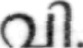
വി.
